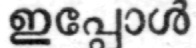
ഇപ്പോള്‍
